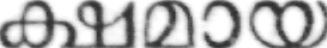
ക്ഷമായ
